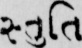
સ્તુતિ
